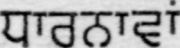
ਧਾਰਨਾਵਾਂ
